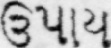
ઉપાય
